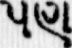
પણ
